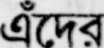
এঁদের
